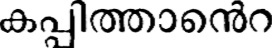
കപ്പിത്താന്റെ
